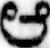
ಆ
